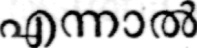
എന്നാല്‍
